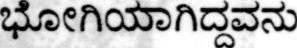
ಭೋಗಿಯಾಗಿದ್ದವನು
